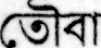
তৌবা
